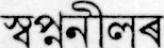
স্বপ্ননীলৰ
